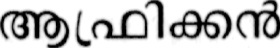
ആഫ്രിക്കന്‍
